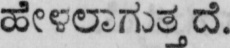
ಹೇಳಲಾಗುತ್ತದೆ.
